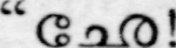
"ഛേ!
